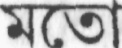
মতো
